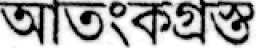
আতংকগ্ৰস্ত
